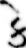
કે
